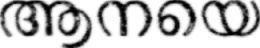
ആനയെ
